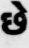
છે
